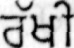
ਰੱਖੀ
